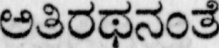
ಅತಿರಥನಂತೆ
